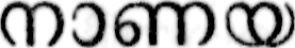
നാണയ
